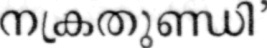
നക്രതുണ്ഡി'
